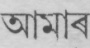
আমাৰ
